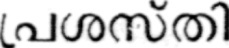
പ്രശസ്തി
